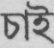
চাই
